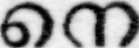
നെ
